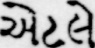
એટલે
